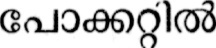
പോക്കറ്റില്‍
